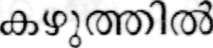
കഴുത്തില്‍
